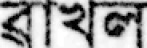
ৱাখল
